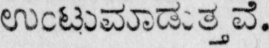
ಉಂಟುಮಾಡುತ್ತವೆ.
